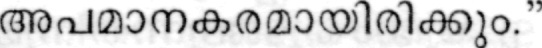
അപമാനകരമായിരിക്കും.”
